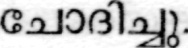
ചോദിച്ചു.
